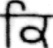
ਕਿ
